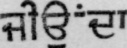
ਜੀਉਂਦਾ
